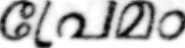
പ്രേമം
